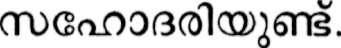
സഹോദരിയുണ്ട്.
